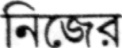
নিজের
